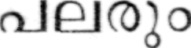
പലരും
